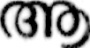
ആ
